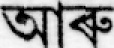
আৰু
